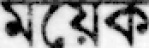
ময়েক
